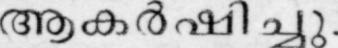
ആകര്‍ഷിച്ചു.
